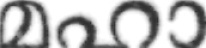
മഹാ
